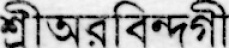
শ্রীঅরবিন্দগী
